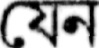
যেন
